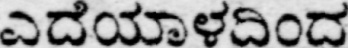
ಎದೆಯಾಳದಿಂದ
